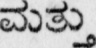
ಮತ್ತು
